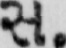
સ.
